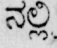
ನಲ್ಲಿ
